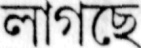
লাগছে
